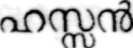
ഹസ്സന്‍
